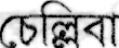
চেল্লিবা
